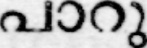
പാറു
